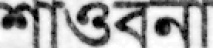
শাওবনা
